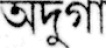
অদুগা
